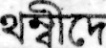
থম্বীদে
